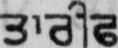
ਤਾਰੀਫ
